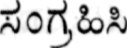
ಸಂಗ್ರಹಿಸಿ
